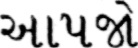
આપજો
